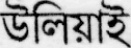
উলিয়াই
